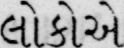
લોકોએ
